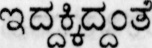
ಇದ್ದಕ್ಕಿದ್ದಂತೆ
